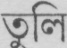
তুলি
